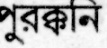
পুরক্কনি
